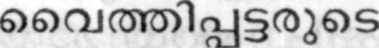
വൈത്തിപ്പട്ടരുടെ
